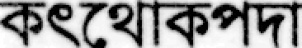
কৎথোকপদা
